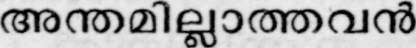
അന്തമില്ലാത്തവന്‍
